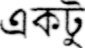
একটু
